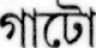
গাটো
